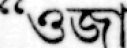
“ওজা
